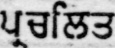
ਪ੍ਰਚਲਿਤ
